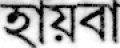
হায়বা
